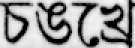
চঙখ্রে
